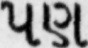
પણ
